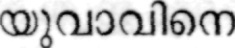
യുവാവിനെ
